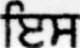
ਇਸ
